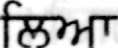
ਲਿਆ
